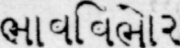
ભાવવિભોર
